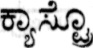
ಕ್ಯಾಸ್ಟ್ರೂ
